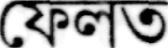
ফেলত
